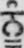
ਨੂੰ
